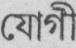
যোগী
